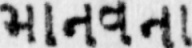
માનવના
